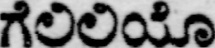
ಗೆಲಿಲಿಯೊ
